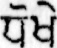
ਧੋਖੇ
